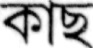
কাছ
